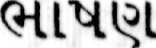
ભાષણ
